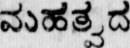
ಮಹತ್ವದ
